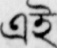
এই
